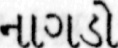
નાગડો
